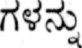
ಗಳನ್ನು
